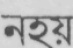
নহয়
